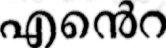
എന്റെ
